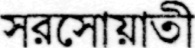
সরসোয়াতী
